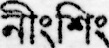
নীংশিং
